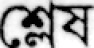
শ্লেষ
